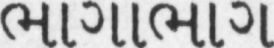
ભાગાભાગ
